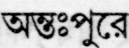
অন্তঃপুরে
